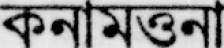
কনামত্তনা
